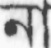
না
